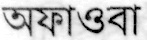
অফাওবা
